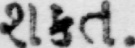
શકત.
